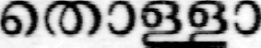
തൊള്ളാ
